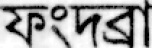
ফংদব্রা
